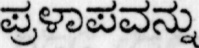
ಪ್ರಳಾಪವನ್ನು
